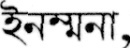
ইনম্মনা,
